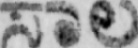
ಸಾಲ
